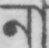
না
